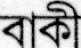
বাকী
